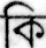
কি
